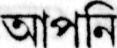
আপনি
